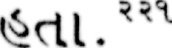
હતા.૨૨૧
